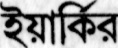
ইয়ার্কির
